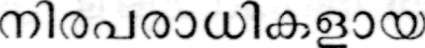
നിരപരാധികളായ
